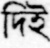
দিই
